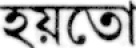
হয়তো
